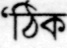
‘ঠিক
